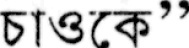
চাওকে”
